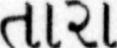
તારા
